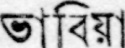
ভাবিয়া
